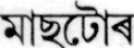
মাছটোৰ
